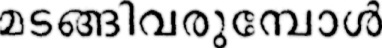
മടങ്ങിവരുമ്പോള്‍
